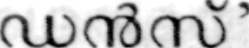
ഡന്‍സ്'
